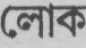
লোক
